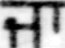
ਜਾ
